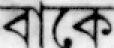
বাকে
